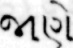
જાણે
